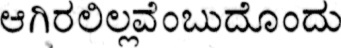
ಆಗಿರಲಿಲ್ಲವೆಂಬುದೊಂದು
